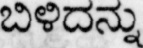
ಬಿಳಿದನ್ನು
